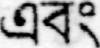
এবং
